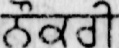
ਨੌਕਰੀ
